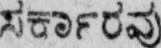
ಸರ್ಕಾರವು
